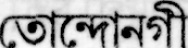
তোন্দোনগী
